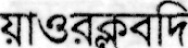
য়াওরক্লবদি
